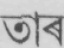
তাৰ
